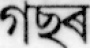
গছৰ
